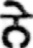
ਨੇ
